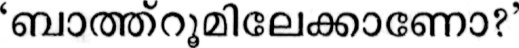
'ബാത്ത്റൂമിലേക്കാണോ?'
